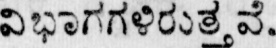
ವಿಭಾಗಗಳಿರುತ್ತವೆ.
